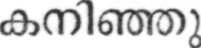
കനിഞ്ഞു
